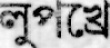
লুপখ্রে
